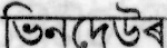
ভিনদেউৰ
